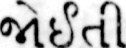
જોઈતી
